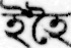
ইহৈ
